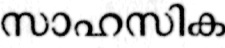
സാഹസിക
